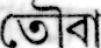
তৌবা
